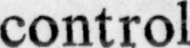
control
